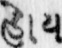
હોય
